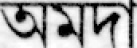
অমদা
